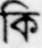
কি
